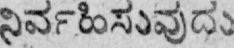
ನಿರ್ವಹಿಸುವುದು
